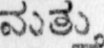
ಮತ್ತು
